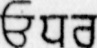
ਓਧਰ
